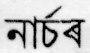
নার্চৰ
